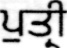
ਪੁਤ੍ਰੀ
